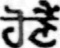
ਹੋਣੈਂ
